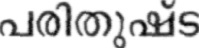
പരിതുഷ്ട
